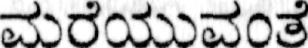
ಮರೆಯುವಂತೆ
